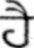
ਹੈ
